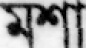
মশা
